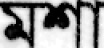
মশা
